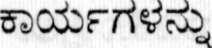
ಕಾರ್ಯಗಳನ್ನು
